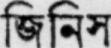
জিনিস
